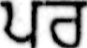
ਪਰ
